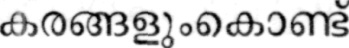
കരങ്ങളുംകൊണ്ട്
